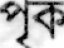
পৃক
